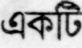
একটি
